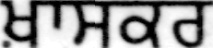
ਖ਼ਾਸਕਰ
